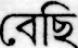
বেছি
